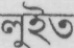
লুইত
